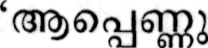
'ആപ്പെണ്ണു
